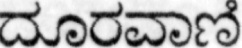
ದೂರವಾಣಿ
